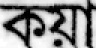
কয়া
